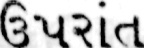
ઉપરાંત
